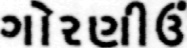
ગોરણીઉં
